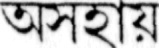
অসহায়
